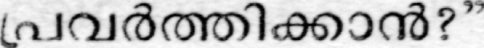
പ്രവര്‍ത്തിക്കാന്‍?''
